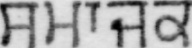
ਸਮਾਜਕ
